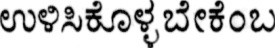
ಉಳಿಸಿಕೊಳ್ಳಬೇಕೆಂಬ
